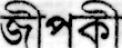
জীপকী
